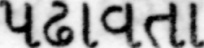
પઢાવતા
